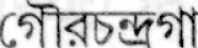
গৌরচন্দ্রগা
